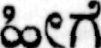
ಹೀಗೆ
